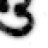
ও
